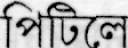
পিটিলে
